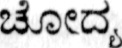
ಚೋದ್ಯ
